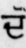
ਦੋ
